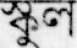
স্কুল
